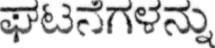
ಘಟನೆಗಳನ್ನು
